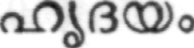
ഹൃദയം
